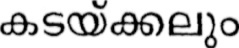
കടയ്ക്കലും
